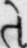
તે
